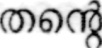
തന്റെ
